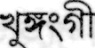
খুঙ্গংগী
